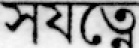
সযত্নে
